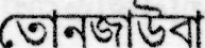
তোনজাউবা
